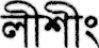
লীশীং
